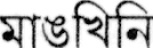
মাঙখিনি
